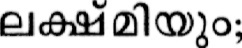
ലക്ഷ്മിയും;
